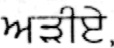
ਅੜੀਏ,
